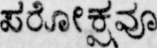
ಪರೋಕ್ಷವೂ
